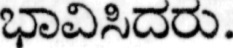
ಭಾವಿಸಿದರು.
